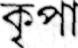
কৃপা
